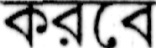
করবে
